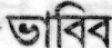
ভাবিব
